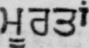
ਮੂਰਤਾਂ
